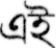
এই
